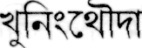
খুনিংথৌদা
